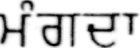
ਮੰਗਦਾ
